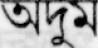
অদুম
